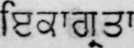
ਇਕਾਗ੍ਰਤਾ
